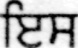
ਇਸ
